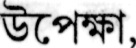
উপেক্ষা,
